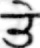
ਤੇ
